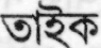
তাইক
